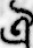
ঐ
